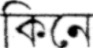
কিনে
